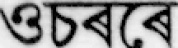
ওচৰৰে
